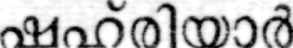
ഷഹ്രിയാര്‍
